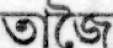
তাজৈ
